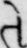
તે
